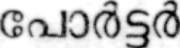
പോര്‍ട്ടര്‍
